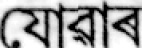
যোৱাৰ
